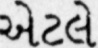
એટલે
